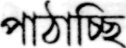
পাঠাচ্ছি
